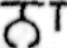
ਨਾ
